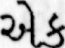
એક
